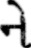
ને
